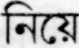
নিয়ে
